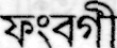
ফংবগী
